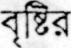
বৃষ্টির
